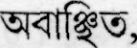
অবাঞ্ছিত,
